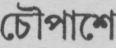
চৌপাশে
